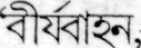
'বীর্যবাহন,
